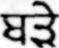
ਬੜੇ
